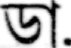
ডা.
